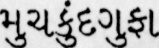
મુચકુંદગુફા
